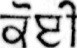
ਕੋਈ
